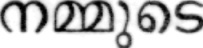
നമ്മുടെ
